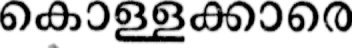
കൊള്ളക്കാരെ
